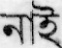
নাই
